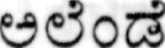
ಅಲೆಂಡೆ
